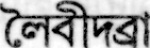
লৈবীদব্রা
